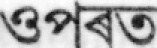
ওপৰত
